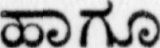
ಹಾಗೂ
